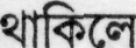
থাকিলে
